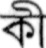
কী
